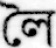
লৈ
